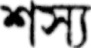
শস্য
